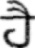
ਹੈ
